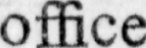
office
